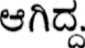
ಆಗಿದ್ದ.
